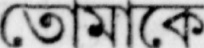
তোমাকে
